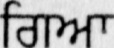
ਗਿਆ
